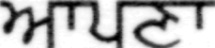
ਆਪਣਾ
